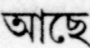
আছে
